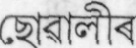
ছোৱালীৰ
